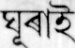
ঘূৰাই
